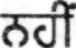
ਨਹੀਂ
